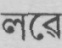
লৱে
